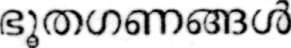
ഭൂതഗണങ്ങള്‍
